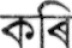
কৰি
